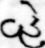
વ્હે
